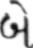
બે
